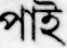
পাই
